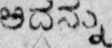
ಅದನ್ನು
